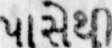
પાસેથી
